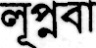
লূপ্নবা
